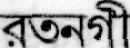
রতনগী
